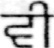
ਵੀ
